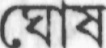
ঘোষ
